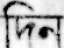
দিন
